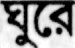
ঘুরে
